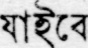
যাইবে
